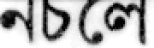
নচলে
